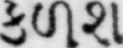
કળશ
